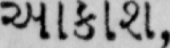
આકાશ,
